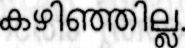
കഴിഞ്ഞില്ല.
